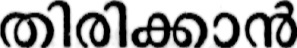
തിരിക്കാന്‍
